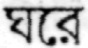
ঘরে
